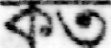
কত
